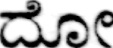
ದೋ
